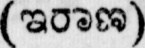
(ಇರಾಣ)
